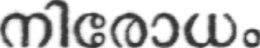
നിരോധം
